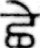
ਛੇ
